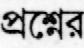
প্রশ্নের
